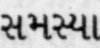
સમસ્યા
